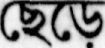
ছেড়ে
